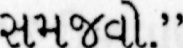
સમજવો."
